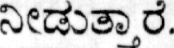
ನೀಡುತ್ತಾರೆ.
